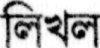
লিখল
